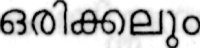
ഒരിക്കലും
